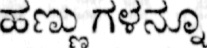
ಹಣ್ಣುಗಳನ್ನೂ
